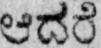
ಆದರೆ
